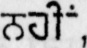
ਨਹੀਂ,
